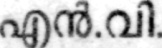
എന്‍.വി.
